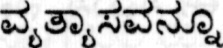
ವ್ಯತ್ಯಾಸವನ್ನೂ
